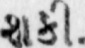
શકી.
